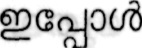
ഇപ്പോള്‍
